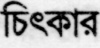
চিত্কার
